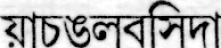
য়াচঙলবসিদা
